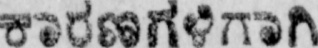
ಕಾರಣಗಳಿಗಾಗಿ
